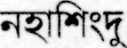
নহাশিংদু
